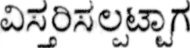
ವಿಸ್ತರಿಸಲ್ಪಟ್ಟಾಗ
